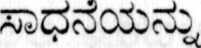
ಸಾಧನೆಯನ್ನು
